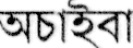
অচাইবা
